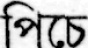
পিচে
